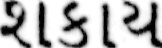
શકાય
